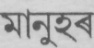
মানুহৰ
